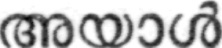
അയാള്‍
